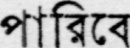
পারিবে
